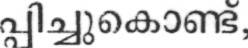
പ്പിച്ചുകൊണ്ട്,
